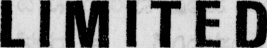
LIMITED
